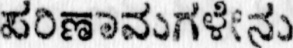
ಪರಿಣಾಮಗಳೇನು
